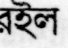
রইল
